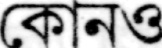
কোনও
